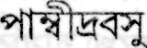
পাম্বীদ্রবসু
